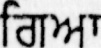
ਗਿਆ
